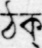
ঠক্
